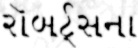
રૉબર્ટસના
